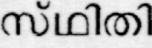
സ്ഥിതി
